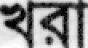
খরা
